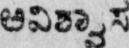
ಅವಿಶ್ವಾಸ
